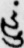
હું
